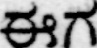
ಈಗ
